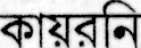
কায়রনি
